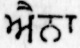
ਐਨਾ
